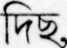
দিছ,
